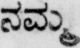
ನಮ್ಮ
